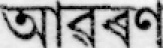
আৱৰণ
